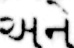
અને
